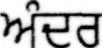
ਅੰਦਰ
